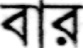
বার
